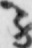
કે
